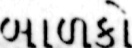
બાળકો
